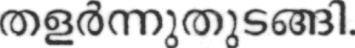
തളര്‍ന്നുതുടങ്ങി.
